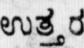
ಉತ್ತರ
